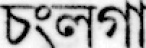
চংলগা
